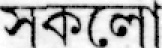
সকলো
